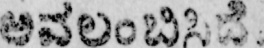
ಅವಲ೦ಬಿಸಿದೆ
